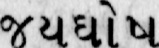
જયઘોષ
